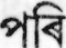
পৰি
